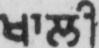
ਖਾਲੀ
